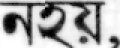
নহয়,
